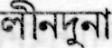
লীনদুনা
